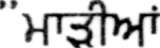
''ਮਾੜੀਆਂ
